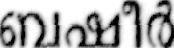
ബഷീര്‍
